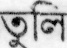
তুলি
